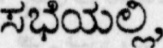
ಸಭೆಯಲ್ಲಿ,
